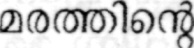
മരത്തിന്റെ
